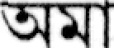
অমা
